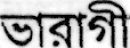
ভারাগী
